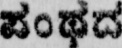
ಪಂಥದ
